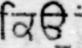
ਕਿਉਂ
